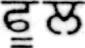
ਫੂਲ
